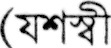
(যশস্বী
